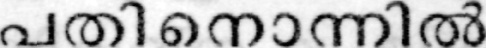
പതിനൊന്നില്‍
